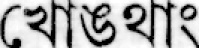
খোঙথাং
